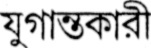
যুগান্তকারী
